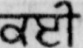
ਕਈ
